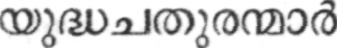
യുദ്ധചതുരന്മാര്‍
